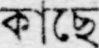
কাছে
